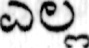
ಎಲ್ಲ
